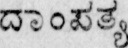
ದಾಂಪತ್ಯ
